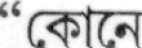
"কোনে
